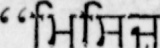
''ਮਿਸਿਜ਼
